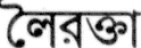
লৈরক্তা
